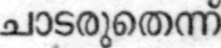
ചാടരുതെന്ന്
